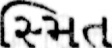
સ્મિત
